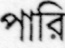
পারি
